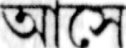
আসে
